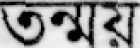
তন্ময়
